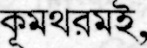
কূমথরমই,
